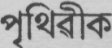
পৃথিৱীক
